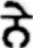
ਨੇ
